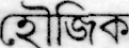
হৌজিক
